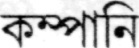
কম্পানি
